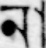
না
